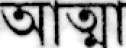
অত্মা
